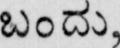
ಬಂದು,
